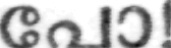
പോ!
